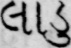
લાડુ
